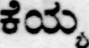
ಕೆಯ್ಯ
